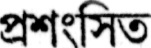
প্রশংসিত
